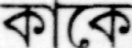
কাকে
